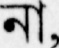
না,
